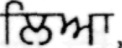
ਲਿਆ,
